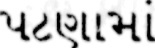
પટણામાં
